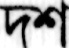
দশ
